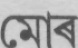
মোৰ
